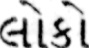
લોકો
